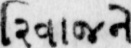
રિવાજને
